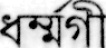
ধর্ম্মগী
